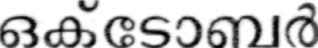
ഒക്ടോബര്‍
